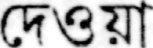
দেওয়া
